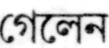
গেলেন
